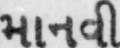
માનવી
